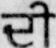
ਦੀ
